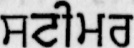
ਸਟੀਮਰ
